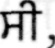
ਸੀ,
